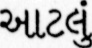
આટલું
